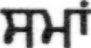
ਸਮਾਂ
